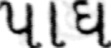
પાધ
